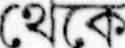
থেকে
